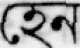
হেন
